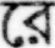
রে
